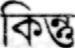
কিন্তু
